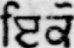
ਇਕੋ
